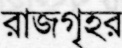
রাজগৃহর
